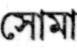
সোমা
